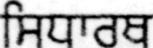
ਸਿਧਾਰਥ
